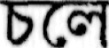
চলে
